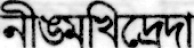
নীঙমখিদ্রেদা
